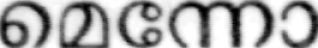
മെന്നോ
